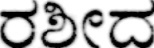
ರಶೀದ
